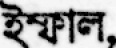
ইম্ফাল,
